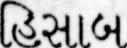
હિસાબ
